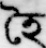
হৈ
